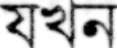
যখন
